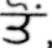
ਤੋਂ,
